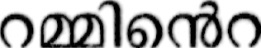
റമ്മിന്റെ
